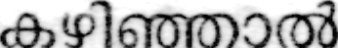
കഴിഞ്ഞാല്‍
